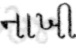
નાખી
